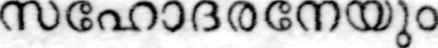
സഹോദരനേയും
